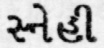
સ્નેહી
